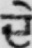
ਦੇ
